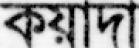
কয়াদা
